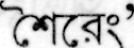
শৈরেং’
